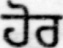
ਹੋਰ
